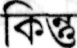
কিন্তু
